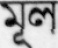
মূল
